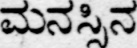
ಮನಸ್ಸಿನ
